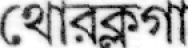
থোরক্লগা
